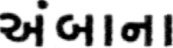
અંબાના
